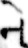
ને
